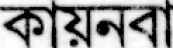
কায়নবা
